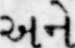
અને
